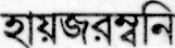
হায়জরম্বনি
